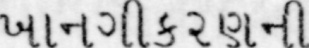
ખાનગીકરણની
